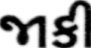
જાકી
